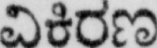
ವಿಕಿರಣ
